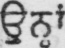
ਉਨ੍ਹਾਂ
